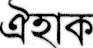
ঐহাক
